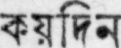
কয়দিন
